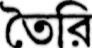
তৈরি
